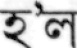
হ'ল
